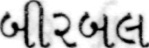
બીરબલ
